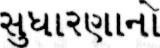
સુધારણાનો
